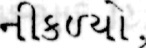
નીકળ્યો,
